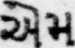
એમ
